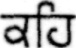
ਕਹਿ
